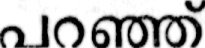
പറഞ്ഞ്
